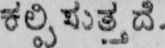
ಕಲ್ಪಿಸುತ್ತದೆ.
